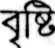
বৃষ্টি
